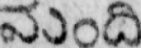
ಮಂದಿ
